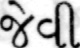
જેવી
